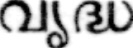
വൃദ്ധ
